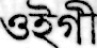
ওইগী
